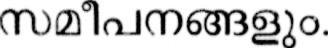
സമീപനങ്ങളും.
